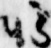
પડે
